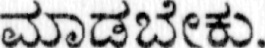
ಮಾಡಬೇಕು.
